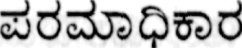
ಪರಮಾಧಿಕಾರ
